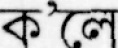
ক'লে
